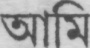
আমি
